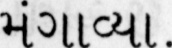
મંગાવ્યા.
